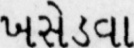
ખસેડવા
